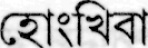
হোংখিবা
